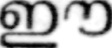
ഈ
